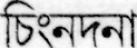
চিংনদনা
